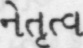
નેતૃત્વ
